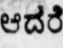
ಆದರೆ
